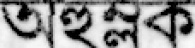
অহম্লক
